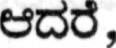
ಆದರೆ,
